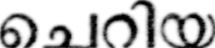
ചെറിയ
